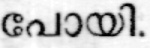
പോയി.
